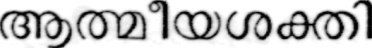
ആത്മീയശക്തി
